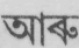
আৰু
